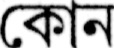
কোন
